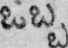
ಒಬ್ಬ
